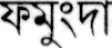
ফমুংদা
